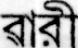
ৱারী
